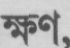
ক্ষণ,
